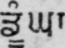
ਡੂੰਘਾ
